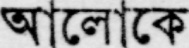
আলোকে
